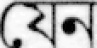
যেন
